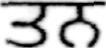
ਤਨ
